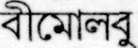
বীমোলবু
